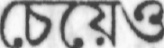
চেয়েও
